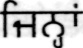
ਜਿਨ੍ਹਾਂ
